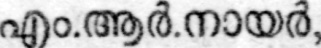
എം.ആര്‍.നായര്‍,
